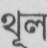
থূল
